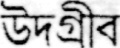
উদগ্রীব
